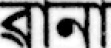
ৱানা
